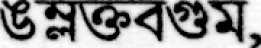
ঙম্লক্তবগুম,
